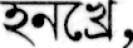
হনখ্রে,
